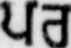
ਪਰ
